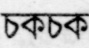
চকচক
